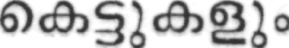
കെട്ടുകളും
